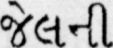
જેલની
